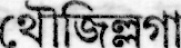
থৌজিল্লগা
